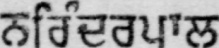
ਨਰਿੰਦਰਪਾਲ
